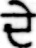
ਦੇ
